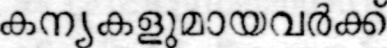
കന്യകളുമായവര്‍ക്ക്
